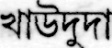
খাউদুদ
